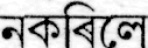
নকৰিলে
